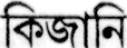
কিজানি
